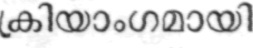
ക്രിയാംഗമായി
